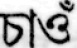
চাওঁ
